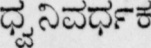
ಧ್ವನಿವರ್ಧಕ
